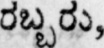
ರಬ್ಬರು,
